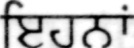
ਇਹਨਾਂ
